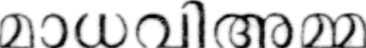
മാധവിഅമ്മ
